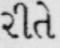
રીતે
